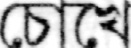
চোখে
